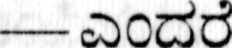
-ಎಂದರೆ
